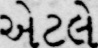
એટલે
